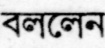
বললেন
